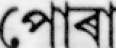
পোৰা
